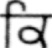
ਕਿ
